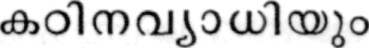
കഠിനവ്യാധിയും
